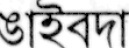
ঙাইবদা
